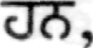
ਹਨ,
